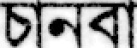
চানবা
